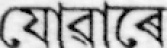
যোৱাৰে
